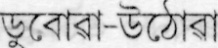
ডুবোৱা-উঠোৱা
